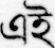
এই
